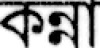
কন্না
